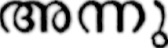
അന്നു
